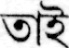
তাই
